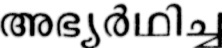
അഭ്യര്‍ഥിച്ച
